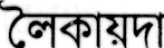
লৈকায়দা
